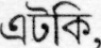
এটকি,
